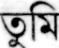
তুমি
